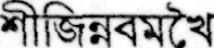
শীজিন্নবমখৈ
